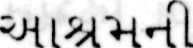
આશ્રમની
